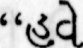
"હવે
